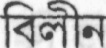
বিলীন
